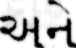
અને
